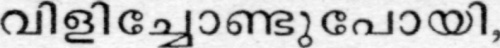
വിളിച്ചോണ്ടുപോയി,
